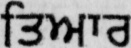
ਤਿਆਰ
